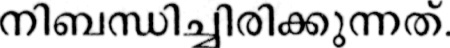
നിബന്ധിച്ചിരിക്കുന്നത്.
